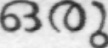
ഒരു
